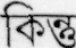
কিন্তু
